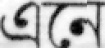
এনে
